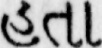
હતા
